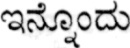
ಇನ್ನೊಂದು
